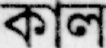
কাল
